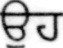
ਉਹ
